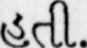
હતી.
